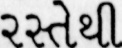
રસ્તેથી
